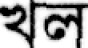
খল
